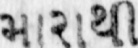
મારાથી
